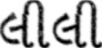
લીલી
